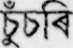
চুঁচৰি
